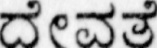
ದೇವತೆ
